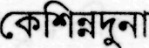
কেশিন্নদুনা
